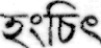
হংচিৎ
